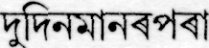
দুদিনমানৰপৰা
